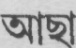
আছা
